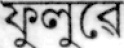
ফুলুৱে
